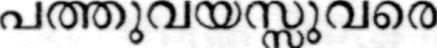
പത്തുവയസ്സുവരെ
